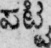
ಪಟ್ಟಿ
